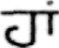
ਹਾਂ
